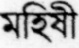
মহিষী
